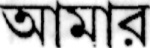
আমার
